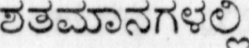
ಶತಮಾನಗಳಲ್ಲಿ
